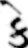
કે
